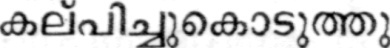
കല്പിച്ചുകൊടുത്തു
